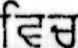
ਵਿਚ
